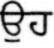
ਉਹ
